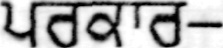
ਪਰਕਾਰ-
